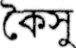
কৈসু
